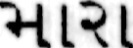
મારા
